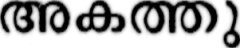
അകത്തു
